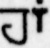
ਹਾਂ
